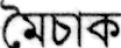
মৈচাক
